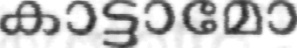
കാട്ടാമോ
